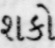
શકો
